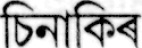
চিনাকিৰ
